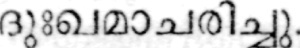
ദുഃഖമാചരിച്ചു.
